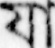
যা
